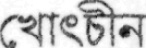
খোৎচীন
